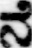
ನೆ
